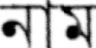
নাম
